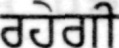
ਰਹੇਗੀ
